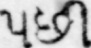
પછી
